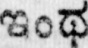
ಇಂಥ
